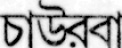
চাউরবা
